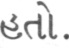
હતો.
